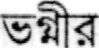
ভগ্নীর
